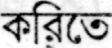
করিতে
